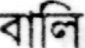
বালি
